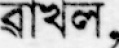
ৱাখল,
